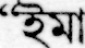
“ইমা
